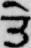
ਤੇ
